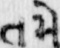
તમે
